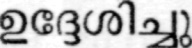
ഉദ്ദേശിച്ചു
